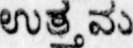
ಉತ್ತಮ
